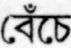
বেঁচে
